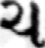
ચ
